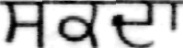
ਸਕਦਾ
